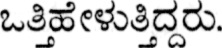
ಒತ್ತಿಹೇಳುತ್ತಿದ್ದರು.
